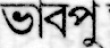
ভাবপু
